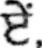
ਏਂ,
